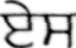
ਏਸ
